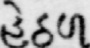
હેઠળ
